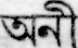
অনী
